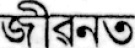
জীৱনত
